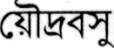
য়ৌদ্রবসু
